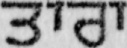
ਤਾਰਾ
